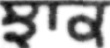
ਝਾਕ
